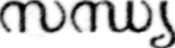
സന്ധ്യ
